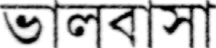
ভালবাসা
